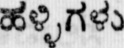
ಹಳ್ಳಿಗಳು
